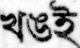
খঙই
